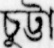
চুট্টা
